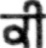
ਕੀ
